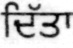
ਦਿੱਤਾ
